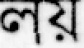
লয়
